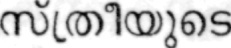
സ്ത്രീയുടെ
